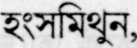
হংসমিথুন,
